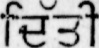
ਦਿੱਤੀ
